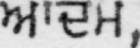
ਆਦਮ,
